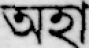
অহা
